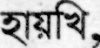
হায়খি,
